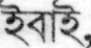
ইবাই,
